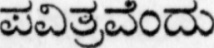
ಪವಿತ್ರವೆಂದು
